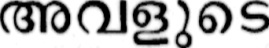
അവളുടെ
